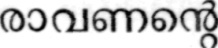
രാവണന്റെ
